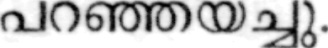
പറഞ്ഞയച്ചു.
